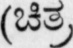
(ಚಿತ್ರ
